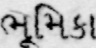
ભૂમિકા
